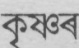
কৃষ্ণৰ
